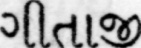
ગીતાજી
